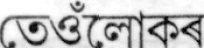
তেওঁলোকৰ
